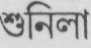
শুনিলা
